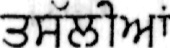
ਤਸੱਲੀਆਂ
